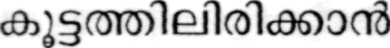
കൂട്ടത്തിലിരിക്കാന്‍
